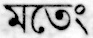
মতেং
